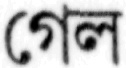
গেল
